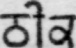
ਠੀਕ
